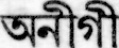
অনীগী
